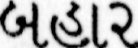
બહાર
